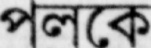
পলকে
